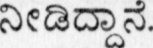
ನೀಡಿದ್ದಾನೆ.
